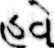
હવે
